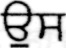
ਉਸ
